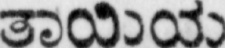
ತಾಯಿಯ
